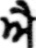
ਐ
